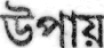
উপায়
